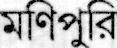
মণিপুরি
